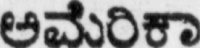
ಅಮೆರಿಕಾ
